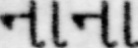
નાના
